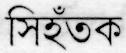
সিহঁতক
